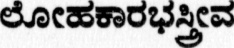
ಲೋಹಕಾರಭಸ್ತ್ರೀವ
